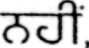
ਨਹੀਂ,
